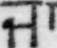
ਜਾ
